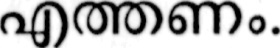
എത്തണം.
